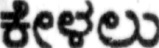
ಕೇಳಲು
